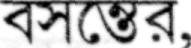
বসন্তের,
